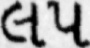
લપ
